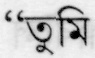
"তুমি
